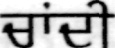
ਚਾਂਦੀ
